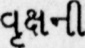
વૃક્ષની
